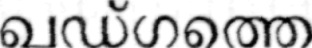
ഖഡ്ഗത്തെ
